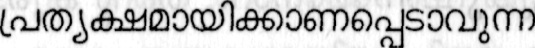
പ്രത്യക്ഷമായിക്കാണപ്പെടാവുന്ന
